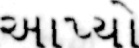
આપ્યો
